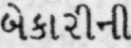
બેકારીની
